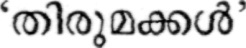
‘തിരുമക്കള്‍’
